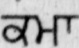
ਕਮਾ
